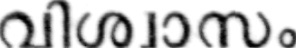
വിശ്വാസം
